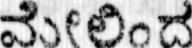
ಮೇಲಿಂದ
